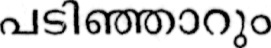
പടിഞ്ഞാറും
